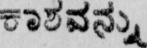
ಕಾಶವನ್ನು
